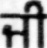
ਜੀ
